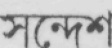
সন্দেশ
